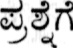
ಪ್ರಶ್ನೆಗೆ
